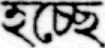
হচ্ছে
